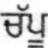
ਚੱਪੂ
